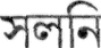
সলনি
